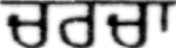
ਚਰਚਾ
